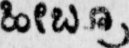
ಹೀಬ್ರೂ
